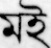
মই
